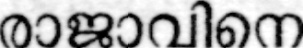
രാജാവിനെ
